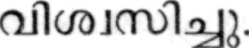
വിശ്വസിച്ചു.
